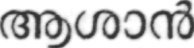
ആശാന്‍
